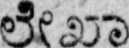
ಲೇಖಾ
